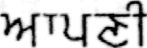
ਆਪਣੀ
